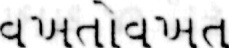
વખતોવખત
